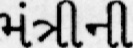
મંત્રીની
